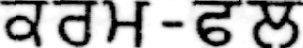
ਕਰਮ-ਫਲ
